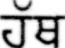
ਹੱਥ
